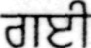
ਗਈ
